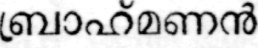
ബ്രാഹ്മണന്‍
